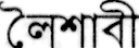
লৈশাবী
